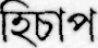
হিচাপ
